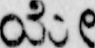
ಯೇ
